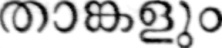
താങ്കളും
